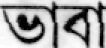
ভাবা
